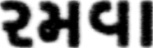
રમવા
